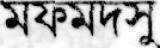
মফমদসু
